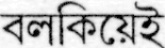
বলকিয়েই
